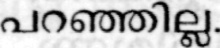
പറഞ്ഞില്ല.
